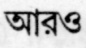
আরও
